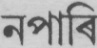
নপাৰি
